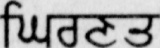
ਘਿਰਣਤ
